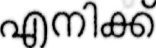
എനിക്ക്
